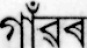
গাঁৱৰ
